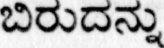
ಬಿರುದನ್ನು
